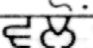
ਵਲੋਂ
